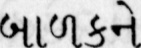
બાળકને
